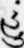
હું
